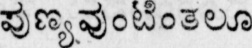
ಪುಣ್ಯವುಂಟೆಂತಲೂ
